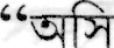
“অসি
